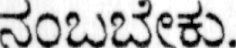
ನಂಬಬೇಕು.
